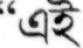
"এই
